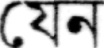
যেন
